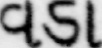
વડા
